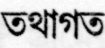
তথাগত
